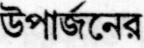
উপার্জনের
